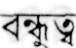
বন্ধুত্ব
